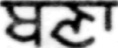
ਬਣਾ
